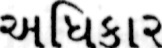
અધિકાર
